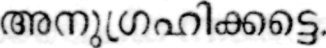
അനുഗ്രഹിക്കട്ടെ.
